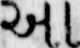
આ
